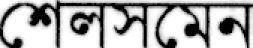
শেলসমেন
